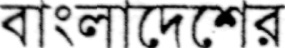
বাংলাদেশের
